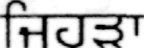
ਜਿਹੜਾ
